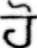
ਹੋ
